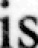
is
